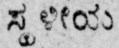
ಸ್ಥಳೀಯ
